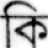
কি
